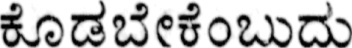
ಕೊಡಬೇಕೆಂಬುದು
